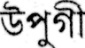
উপুগী
